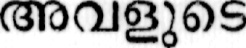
അവളുടെ
